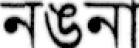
নঙনা
